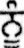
ਨੂੰ
